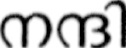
നന്ദി
